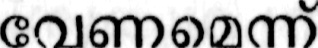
വേണമെന്ന്
